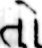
તો
